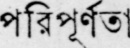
পরিপূর্ণতা
